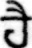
ਹੈ
